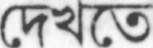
দেখতে
